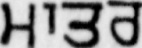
ਮਾਤਰ
